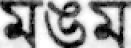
মঙম
